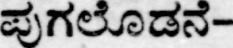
ಪುಗಲೊಡನೆ-
